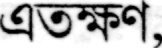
এতক্ষণ,
